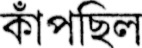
কাঁপছিল
